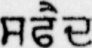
ਸਫੈਦ
